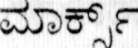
ಮಾರ್ಕ್ಸ್
